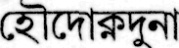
হৌদোক্নদুনা
